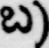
ಬ)
